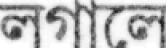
লগালে
